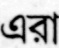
এরা
